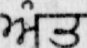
ਅੰਤ
